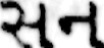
સન
